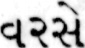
વરસે
